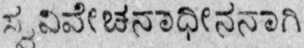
ಸ್ವವಿವೇಚನಾಧೀನನಾಗಿ
